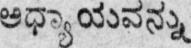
ಅಧ್ಯಾಯವನ್ನು
